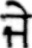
ਜੇ
